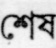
শেষ
